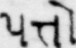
પત્તો
